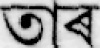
তাৰ
